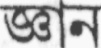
জ্ঞান
